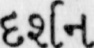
દર્શન
